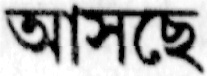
আসছে
